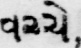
વચ્ચે,
